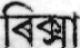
ৰিক্সা
